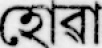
হোৱা
